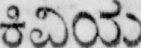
ಕಿವಿಯ
